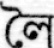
লৈ
